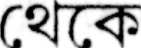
থেকে
